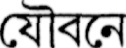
যৌবনে
